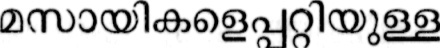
മസായികളെപ്പറ്റിയുള്ള
